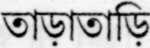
তাড়াতাড়ি
